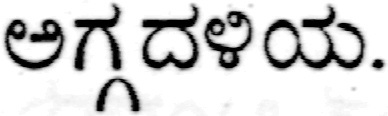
ಅಗ್ಗದಳಿಯ.
